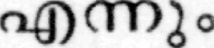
എന്നും
